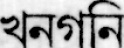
খনগনি
